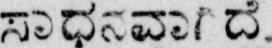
ಸಾಧನವಾಗಿದೆ.
